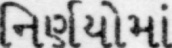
નિર્ણયોમાં
